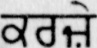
ਕਰਜ਼ੇ
